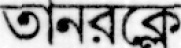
তানরক্লে
